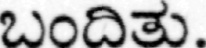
ಬಂದಿತು.
